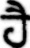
ਹੈ
